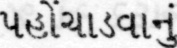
પહોંચાડવાનું
